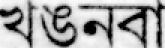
খঙনবা
